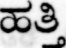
ಹತ್ತಿ
